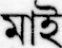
মাই
